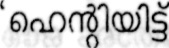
'ഹെന്റിയിട്ട്
